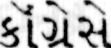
કૉંગ્રેસે
